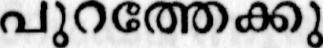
പുറത്തേക്കു
